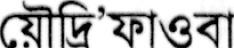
য়ৌদ্রি’ফাওবা
